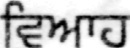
ਵਿਆਹ
